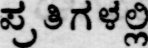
ಪ್ರತಿಗಳಲ್ಲಿ
